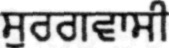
ਸੁਰਗਵਾਸੀ
